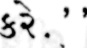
કરે."
